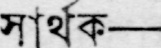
সার্থক—
